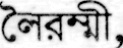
লৈরম্মী,
